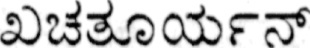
ಖಚತೂರ್ಯನ್
